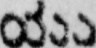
ಯು
